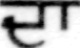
ਦਾ
